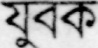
যুবক
